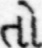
તો
